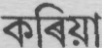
কৰিয়া
